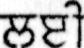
ਲਈ
